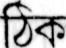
ঠিক
